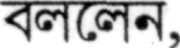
বললেন,
